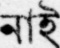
নাই
